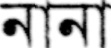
নানা
